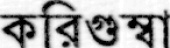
করিগুম্বা
